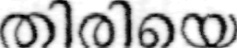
തിരിയെ
